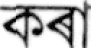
কৰা
